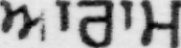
ਆਰਾਮ
